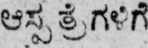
ಆಸ್ಪತ್ರೆಗಳಿಗೆ
